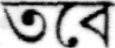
তবে
